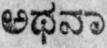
ಅಥವಾ
